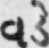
વડે
